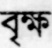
বৃক্ষ
